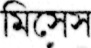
মিসেস
